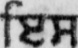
ਇਸ
